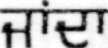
ਜਾਂਦਾ
